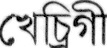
খেচ্রিগী
